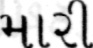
મારી
